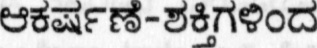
ಆಕರ್ಷಣೆ-ಶಕ್ತಿಗಳಿಂದ
